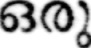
ഒരു
